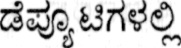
ಡೆಪ್ಯೂಟಿಗಳಲ್ಲಿ
